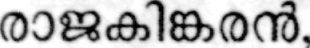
രാജകിങ്കരന്‍,
